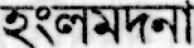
হংলমদনা
